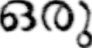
ഒരു
